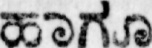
ಹಾಗೂ
